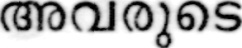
അവരുടെ
